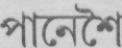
পানেশৈ
